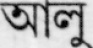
আলু
